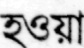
হওয়া
